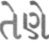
તેણે
